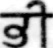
ਭੀ
